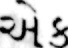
એક
